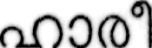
ഹാരീ
